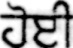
ਹੋਈ
